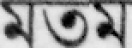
মতম
